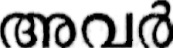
അവര്‍
